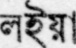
লইয়া
